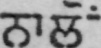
ਨਾਲੋਂ
